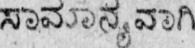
ಸಾಮಾನ್ಯವಾಗಿ
